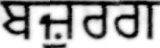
ਬਜ਼ੁਰਗ
